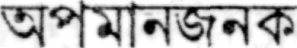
অপমানজনক
